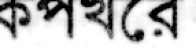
কপখরে
